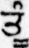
ਤੂੰ
